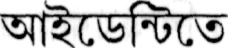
আইডেন্টিতে
